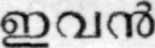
ഇവന്‍
